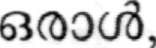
ഒരാള്‍,
